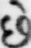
છે
